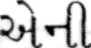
એની
